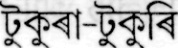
টুকুৰা-টুকুৰি
